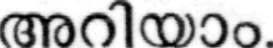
അറിയാം.
